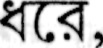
ধরে,
